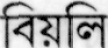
বিয়লি
